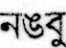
নঙবু
